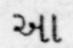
આ
